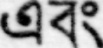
এবং
